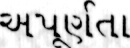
અપૂર્ણતા
